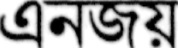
এনজয়
